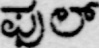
ಫುಲ್
